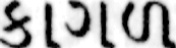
કાગળ
